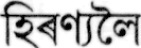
হিৰণ্যলৈ
